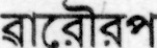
ৱারৌরপ
